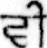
ਵੀ
